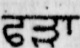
ਫੜਾ
